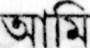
আমি
